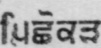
ਪਿਛੋਕੜ
